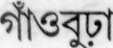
গাঁওবুঢ়া
